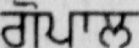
ਗੋਪਾਲ
